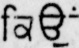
ਕਿਉਂ
